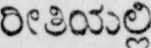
ರೀತಿಯಲ್ಲಿ
